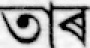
তাৰ
